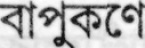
বাপুকণে
